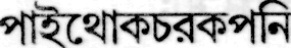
পাইথোকচরকপনি
